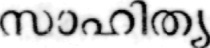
സാഹിത്യ
